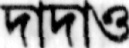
দাদাও
